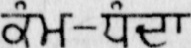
ਕੰਮ-ਧੰਦਾ
